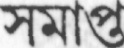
সমাপ্ত
